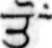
ਤੋਂ
